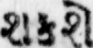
શકશે
